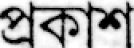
প্রকাশ
